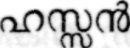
ഹസ്സന്‍
